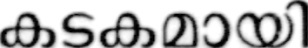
കടകമായി
